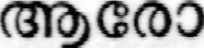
ആരോ
